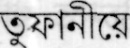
তুফানীয়ে
